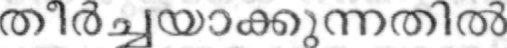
തീര്‍ച്ചയാക്കുന്നതില്‍
